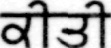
ਕੀਤੀ
